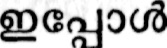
ഇപ്പോള്‍
